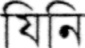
যিনি
